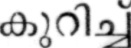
കുറിച്ച്
